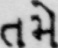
તમે
